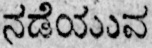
ನಡೆಯುವ
